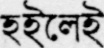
হইলেই
